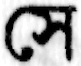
সে
